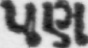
પણ
